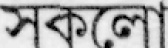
সকলো
